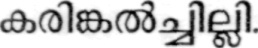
കരിങ്കല്‍ച്ചില്ലി.
